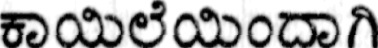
ಕಾಯಿಲೆಯಿಂದಾಗಿ
